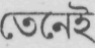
তেনেই
